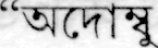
“অদোম্বু
